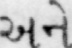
અને
